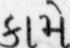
કામે
